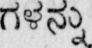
ಗಳನ್ನು
